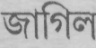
জাগিল
